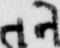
તને
